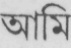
আমি
